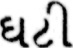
ઘટી
